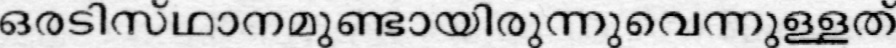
ഒരടിസ്ഥാനമുണ്ടായിരുന്നുവെന്നുള്ളത്
